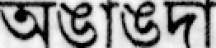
অঙাঙদা
